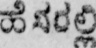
ಹೆಸರಲ್ಲಿ
